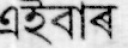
এইবাৰ
